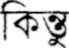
কিন্তু
